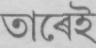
তাৰেই
